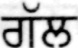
ਗੱਲ
